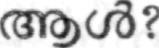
ആള്‍?
